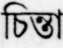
চিন্তা
